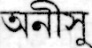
অনীসু
